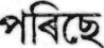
পৰিছে
